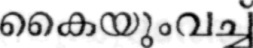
കൈയുംവച്ച്
